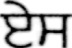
ਏਸ
